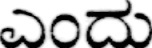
ಎಂದು
